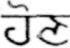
ਹੋਣ
